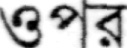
ওপর
